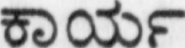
ಕಾರ್ಯ
